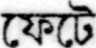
ফেটে
